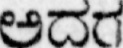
ಅದರ
